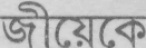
জীয়েকে
